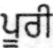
ਪੂਰੀ
